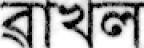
ৱাখল
